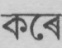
কৰে
